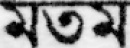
মতম
